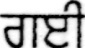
ਗਈ
